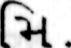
મિ.
